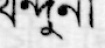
খন্দুনা
